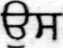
ਉਸ
